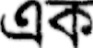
এক
